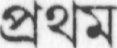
প্রথম
